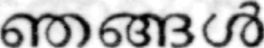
ഞങ്ങള്‍
